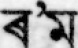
ৰ'ম
